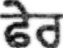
ਫੇਰ
